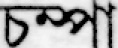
চম্পা
